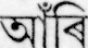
আঁৰি
